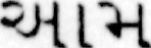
આમ
